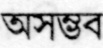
অসম্ভব
